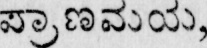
ಪ್ರಾಣಮಯ,
